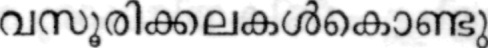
വസൂരിക്കലകള്‍കൊണ്ടു
